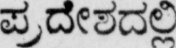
ಪ್ರದೇಶದಲ್ಲಿ
